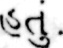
હતું.
